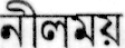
নীলময়
